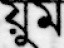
য়ুম
